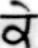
ਕੇ
